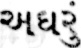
અઘરું
